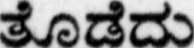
ತೊಡೆದು
